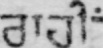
ਰਾਹੀਂ
